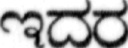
ಇದರ
